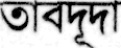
তাবদূদা
